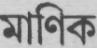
মাণিক
